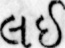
લઈ
